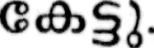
കേട്ടു.
